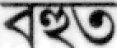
বহুত
